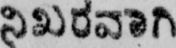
ನಿಖರವಾಗಿ
